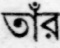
তাঁর
